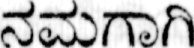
ನಮಗಾಗಿ
